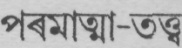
পৰমাত্মা-তত্ত্ব
